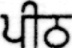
ਪੀਠ
